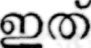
ഇത്
